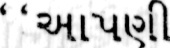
"આપણી
